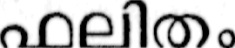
ഫലിതം
